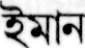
ইমান
